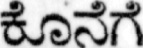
ಕೊನೆಗೆ
